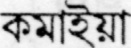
কমাইয়া
